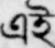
এই
